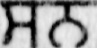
ਸਨ
